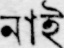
নাই
